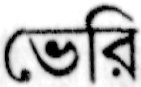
ভেরি
